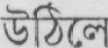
উঠিলে
